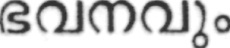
ഭവനവും
